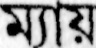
ম্যায়
